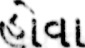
હોવા
